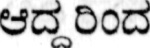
ಆದ್ದರಿಂದ
